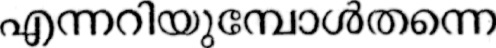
എന്നറിയുമ്പോള്‍തന്നെ
